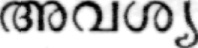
അവശ്യ
